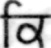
ਕਿ
